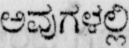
ಅವುಗಳಲ್ಲಿ
